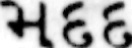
મદદ
